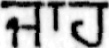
ਜਾਹ
